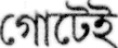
গোটেই
